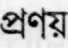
প্রণয়
